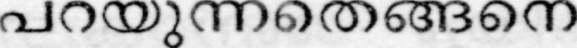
പറയുന്നതെങ്ങനെ
